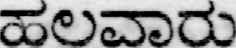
ಹಲವಾರು
